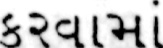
કરવામાં
